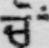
ਚੋਂ
